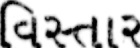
વિસ્તાર
